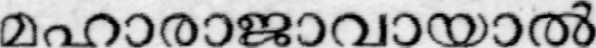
മഹാരാജാവായാല്‍
